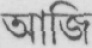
আজি
